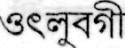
ওৎলুবগী
